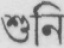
শুনি
